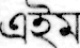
এইম
